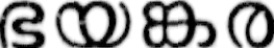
ഭയങ്കര
